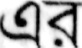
এর
